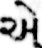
એ
